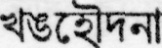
খঙহৌদনা
